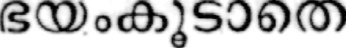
ഭയംകൂടാതെ
